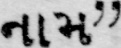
નામ”
